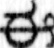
ಈ
